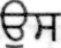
ਉਸ
